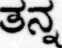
ತನ್ನ
